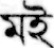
মই
